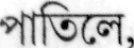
পাতিলে,
